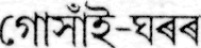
গোসাঁই-ঘৰৰ
